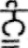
ਨੂੰ
